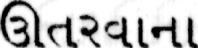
ઊતરવાના
